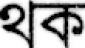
থক
